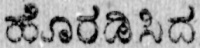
ಹೊರಡಿಸಿದ
